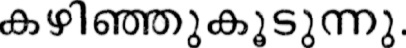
കഴിഞ്ഞുകൂടുന്നു.
